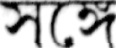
সঙ্গে
